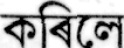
কৰিলে
